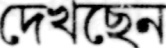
দেখছেন
